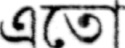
এতো
